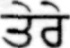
ਤੇਰੇ
